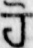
ਹੋ
